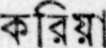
করিয়া
